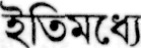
ইতিমধ্যে
